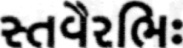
સ્તવૈરભિઃ
